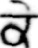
ਕੇ
